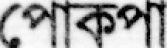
পোকপা
